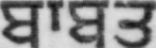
ਬਾਬਤ
